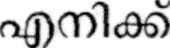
എനിക്ക്
